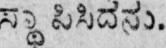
ಸ್ಥಾಪಿಸಿದನು.
